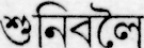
শুনিবলৈ
